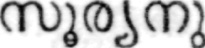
സൂര്യനു
